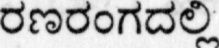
ರಣರಂಗದಲ್ಲಿ
